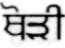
ਥੋੜੀ
